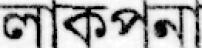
লাকপনা
